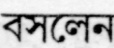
বসলেন
